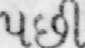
પછી
